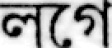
লগে
